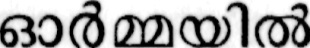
ഓര്‍മ്മയില്‍
